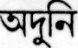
অদুনি
